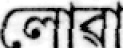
লোৱা
